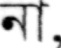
না,
